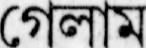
গেলাম
